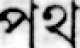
পথ
